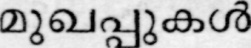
മുഖപ്പുകള്‍
